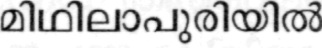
മിഥിലാപുരിയില്‍
